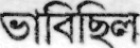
ভাবিছিল
